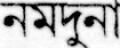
নমদুনা
